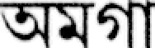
অমগা
